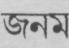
জনম
